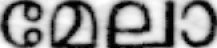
മേലാ
